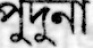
পুদুনা
